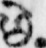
છે.
